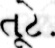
તૂટે.
